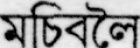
মচিবলৈ
